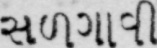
સળગાવી
